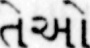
તેઓ
